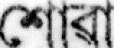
শোৱা
